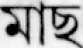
মাছ
